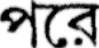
পরে
